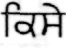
ਕਿਸੇ
